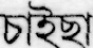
চাইছা
